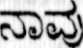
ನಾವು
